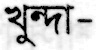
খুন্দা-
